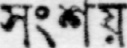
সংশয়
